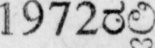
1972ರಲ್ಲಿ
